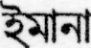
ইমানা
